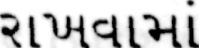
રાખવામાં
